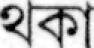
থকা
